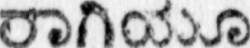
ರಾಗಿಯೂ
